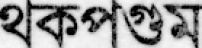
থকপগুম
